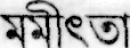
মমীৎতা
